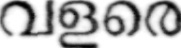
വളരെ
